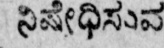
ನಿಷೇಧಿಸುವ
